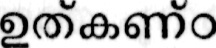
ഉത്കണ്ഠ
